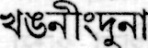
খঙনীংদুনা
